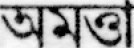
অমত্তা
